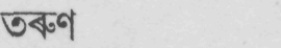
তৰুণ
